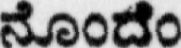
ನೊಂದೆಂ
